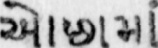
ઓછામાં
